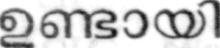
ഉണ്ടായി
